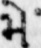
મેં
